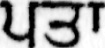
ਪਤਾ
